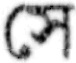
সে
